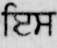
ਇਸ
